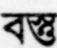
বস্তু
